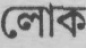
লোক
